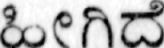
ಹೀಗಿದೆ
